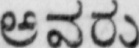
ಅವರು
